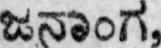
ಜನಾಂಗ,
